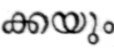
ക്കയും
